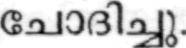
ചോദിച്ചു.
